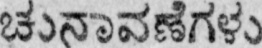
ಚುನಾವಣೆಗಳು
